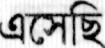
এসেছি
